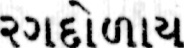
રગદોળાય
